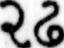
રઢ
